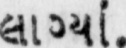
લાગ્યાં.
